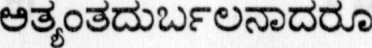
ಅತ್ಯಂತದುರ್ಬಲನಾದರೂ
